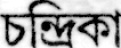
চন্দ্রিকা
